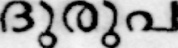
ദുരുപ
